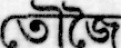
তৌজৈ
